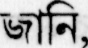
জানি,
